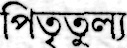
পিতৃতুল্য
